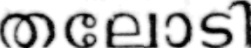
തലോടി
